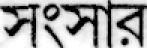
সংসার
